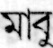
মাবু
